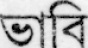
ভাবি
